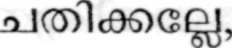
ചതിക്കല്ലേ,
